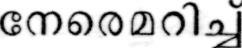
നേരെമറിച്ച്
